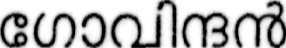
ഗോവിന്ദന്‍
